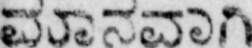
ಮಾನವಾಗಿ
